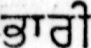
ਭਾਰੀ
